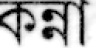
কন্না
